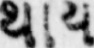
થાય
